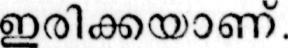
ഇരിക്കയാണ്.
